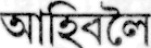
আহিবলৈ
